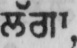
ਲੱਗਾ,
